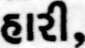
હારી,
